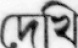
দেখি
